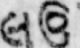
લઉં
